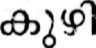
കുഴി
